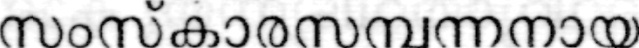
സംസ്കാരസമ്പന്നനായ
